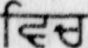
ਵਿਚ
